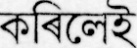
কৰিলেই
